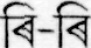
ৰি-ৰি
